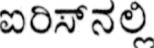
ಐರಿಸ್ನಲ್ಲಿ
